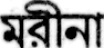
মরীনা
